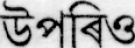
উপৰিও
